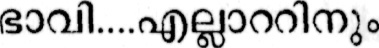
ഭാവി....എല്ലാററിനും
